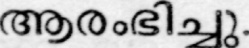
ആരംഭിച്ചു.
